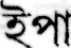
ইপা
